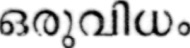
ഒരുവിധം
